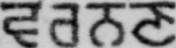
ਵਰਨਣ
